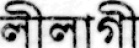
লীলাগী
